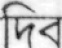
দিব
